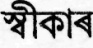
স্বীকাৰ
